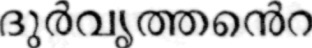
ദുര്‍വൃത്തന്റെ
